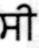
ਸੀ
